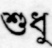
শুধু
